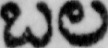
ಬಲ
